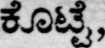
ಕೊಟ್ಟೆ,
